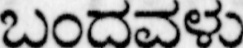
ಬಂದವಳು
